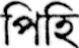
পিহি
